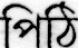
পিঠি
